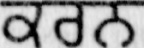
ਕਰਨ
